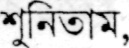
শুনিতাম,
